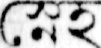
স্নেহ
